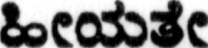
ಹೀಯತೇ
